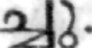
ച്ചു.
